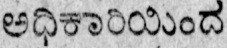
ಅಧಿಕಾರಿಯಿಂದ
